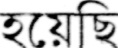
হয়েছি
